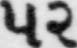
પર
